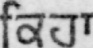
ਕਿਹਾ
